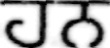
ਹਨ
